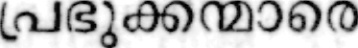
പ്രഭുക്കന്മാരെ
